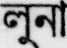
লুনা
